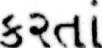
કરતાં
